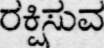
ರಕ್ಷಿಸುವ
